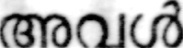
അവള്‍
